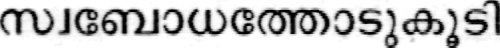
സ്വബോധത്തോടുകൂടി
